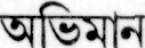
অভিমান
